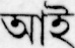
আই
